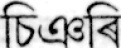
চিঞৰি
